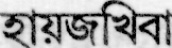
হায়জখিবা
